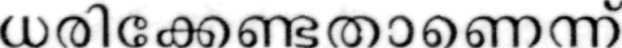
ധരിക്കേണ്ടതാണെന്ന്
